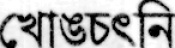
খোঙচৎনি
